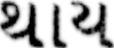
થાય
